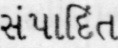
સંપાદિંત
